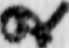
જ
